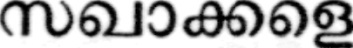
സഖാക്കളെ
